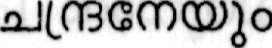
ചന്ദ്രനേയും
